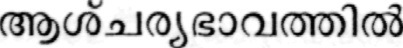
ആശ്ചര്യഭാവത്തില്‍
